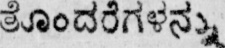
ತೊಂದರೆಗಳನ್ನು
